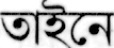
তাইনে
